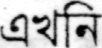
এখনি
